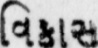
વિકાસ
